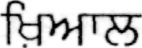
ਖ਼ਿਆਲ
